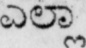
ಎಲ್ಲಾ
